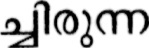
ച്ചിരുന്ന
